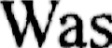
Was
